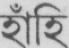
হাঁহি
